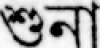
শুনা
